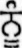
ਨੂੰ
